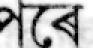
পৰে
